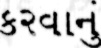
કરવાનું
